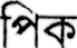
পিক
